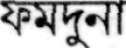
ফমদুনা
